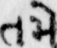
તમે
